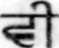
ਵੀ
